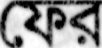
ফের
